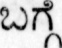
ಬಗ್ಗೆ
